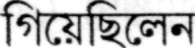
গিয়েছিলেন
